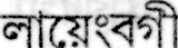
লায়েংবগী
